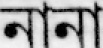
নানা
